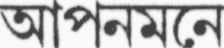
আপনমনে
